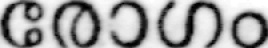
രോഗം
